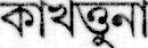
কাখত্তুনা
